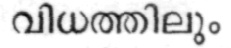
വിധത്തിലും
